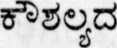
ಕೌಶಲ್ಯದ
